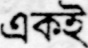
একই
